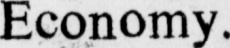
Economy.
